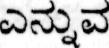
ಎನ್ನುವ
